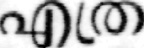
എത്ര
